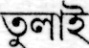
তুলাই
